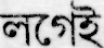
লগেই
